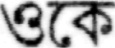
ওকে
